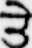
ਤੇ
